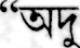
“অদু
